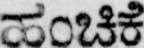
ಹಂಚಿಕೆ
